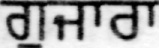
ਗੁਜ਼ਾਰਾ
